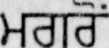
ਮਗਰੋਂ
